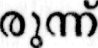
രുന്ന്
